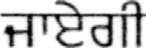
ਜਾਏਗੀ
